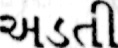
અડતી
